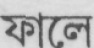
ফালে
